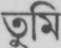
তুমি
